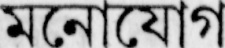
মনোযোগ
